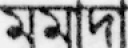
মমাদা
